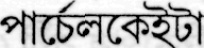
পার্চেলকেইটা
